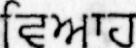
ਵਿਆਹ
